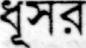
ধূসর
